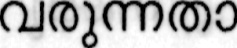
വരുന്നതാ
